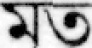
মত
